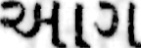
આગ
